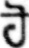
ਹੋ
